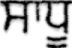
ਸਾਧੂ
